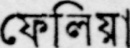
ফেলিয়া
